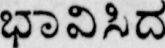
ಭಾವಿಸಿದ
